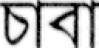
চাবা
